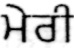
ਮੇਰੀ
